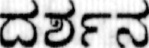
ದರ್ಶನ
